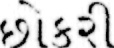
છોકરી
